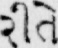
રીતે
